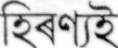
হিৰণ্যই
